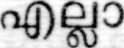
എല്ലാ
